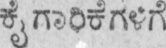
ಕೈಗಾರಿಕೆಗಳಿಗೆ
